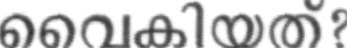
വൈകിയത്?
